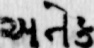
અનેક
